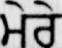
ਮੇਰੇ
